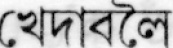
খেদাবলৈ
